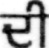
ਦੀ
